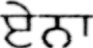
ਏਨਾ
